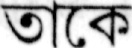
তাকে
